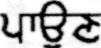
ਪਾਉਣ
